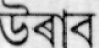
উৰাব
